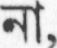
না,
